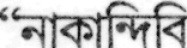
"নাকান্দিবি
